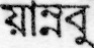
য়াম্নবু
